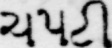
ચપટી
